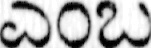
ಎಂಬ
